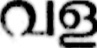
വള
